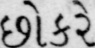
છોકરે
